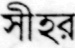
সীহর
